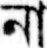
না
